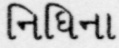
નિધિના
